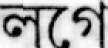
লগে
